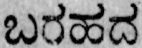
ಬರಹದ
